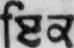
ਇਕ
